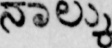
ನಾಲ್ಕು
